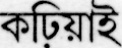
কঢ়িয়াই
